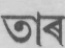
তাৰ
